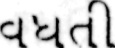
વધતી
